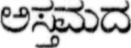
ಅಸ್ತಮದ
